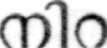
നിറ
